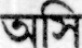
অসি
